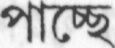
পাচ্ছে
